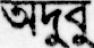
অদুবু
